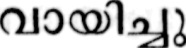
വായിച്ചു
